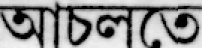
আচলতে
